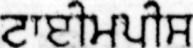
ਟਾਈਮਪੀਸ
